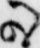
જે
